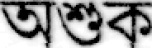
অশুক
